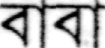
বাবা
